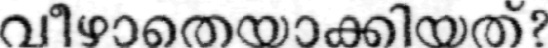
വീഴാതെയാക്കിയത്?
